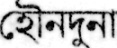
হৌনদুনা
